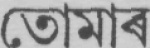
তোমাৰ
